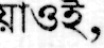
য়াওই,
